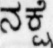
ನಕ್ಷೆ
